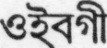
ওইবগী
